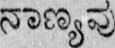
ನಾಣ್ಯವು
